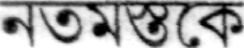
নতমস্তকে
